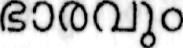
ഭാരവും
